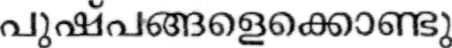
പുഷ്പങ്ങളെക്കൊണ്ടു
